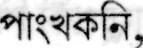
পাংখকনি,
